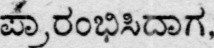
ಪ್ರರಂಭಿಸಿದಾಗ,
